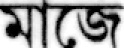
মাজে
